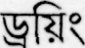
ড্ৰয়িং
